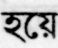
হয়ে
